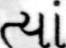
ત્યાં
